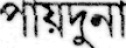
পায়দুনা
